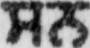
ਸਨ
